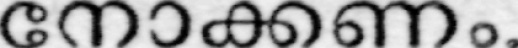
നോക്കണം.
